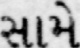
સામે
